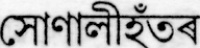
সোণালীহঁতৰ
